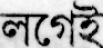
লগেই
